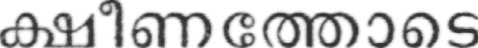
ക്ഷീണത്തോടെ
